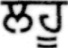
ਲਹੂ
